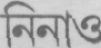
নিনাও
